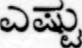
ಎಷ್ಟು
